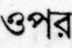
ওপর
